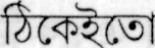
ঠিকেইতো
